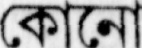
কোনো
